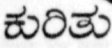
ಕುರಿತು
